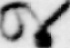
જ
